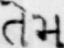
તેમ
